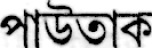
পাউতাক
